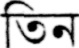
তিন
